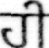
ਹੀ
